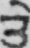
ਤੇ
